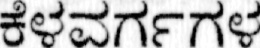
ಕೆಳವರ್ಗಗಳ
